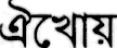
ঐখোয়
